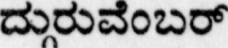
ದ್ಗುರುವೆಂಬರ್
